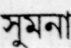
সুমনা
